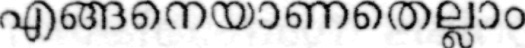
എങ്ങനെയാണതെല്ലാം
